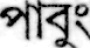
পাবুং
